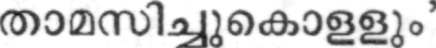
താമസിച്ചുകൊളളും'
